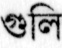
গুলি
